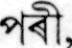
পৰী,
